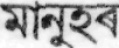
মানুহৰ
